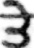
ਤੇ
